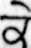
ਕੇ
